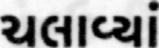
ચલાવ્યાં
